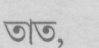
তাত,
